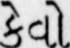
કેવો
